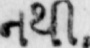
નથી.
